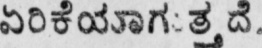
ಏರಿಕೆಯಾಗುತ್ತದೆ.
